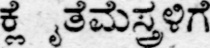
ಕ್ಲೈತೆಮೆಸ್ತ್ರಳಿಗೆ
